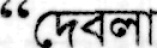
“দেবলা
